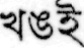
খঙই
